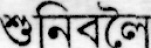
শুনিবলৈ
